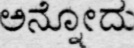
ಅನ್ನೊದು
